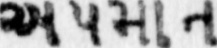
અપમાન
